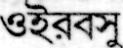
ওইরবসু
